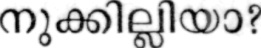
നുക്കില്ലിയാ?
